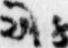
એક
